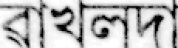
ৱাখলদা
